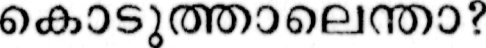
കൊടുത്താലെന്താ?
